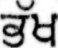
ਭੱਖ
